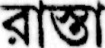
রাস্তা
